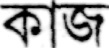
কাজ
